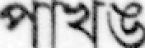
পাখঙ
